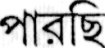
পারছি
